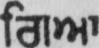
ਗਿਆ
